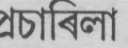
প্ৰচাৰিলা
